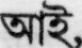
আই,
